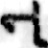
ન
